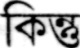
কিন্তু
